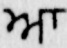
ਆ
